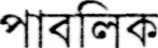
পাবলিক
